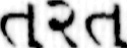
તરત
